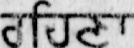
ਰਹਿਣਾ
